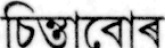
চিন্তাবোৰ
